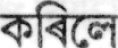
কৰিলে
